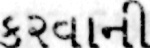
કરવાની
